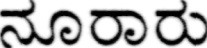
ನೂರಾರು
